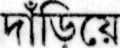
দাঁড়িয়ে
